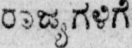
ರಾಜ್ಯಗಳಿಗೆ
